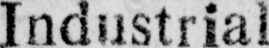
Industrial
